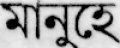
মানুহে
